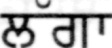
ਲੱਗਾ
